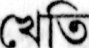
খেতি
